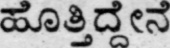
ಹೊತ್ತಿದ್ದೇನೆ
